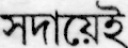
সদায়েই
